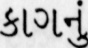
કાગનું
